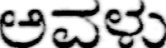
ಅವಳು
